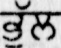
ਭੁੱਲ
